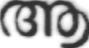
ആ
